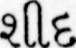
શીદ
